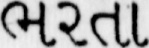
ભરતા
